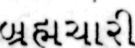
બ્રહ્મચારી
